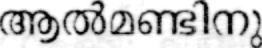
ആല്‍മണ്ടിനു
